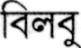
বিলবু
